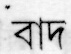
বাদ
